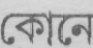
কোনে
